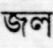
জল
